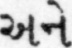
અને
